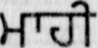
ਮਾਹੀ
